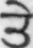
ਤੇ
